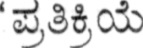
'ಪ್ರತಿಕ್ರಿಯೆ
